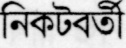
নিকটবর্তী
